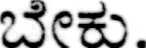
ಬೇಕು.
